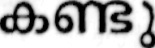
കണ്ടു
